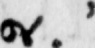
જ.'
